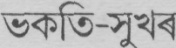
ভকতি-সুখৰ
